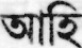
আহি
